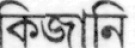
কিজানি
